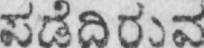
ಪಡೆದಿರುವ
